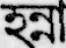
হন্না
